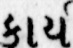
કાર્ય
